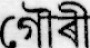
গৌৰী
